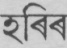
হৰিৰ
